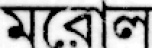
মরোল
